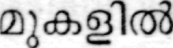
മുകളില്‍
